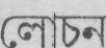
লোচন
